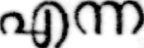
എന്ന
